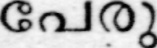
പേരു
